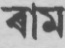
ৰাম
